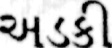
અડકી
